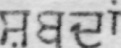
ਸ਼ਬਦਾਂ
